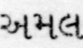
અમલ
